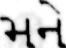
મને
